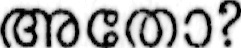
അതോ?
